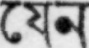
যেন
